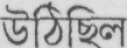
উঠিছিল
